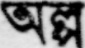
অল্প
